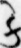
કે
